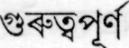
গুৰুত্বপূৰ্ণ
